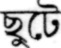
ছুটে
